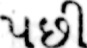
પછી
